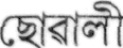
ছোৱালী
